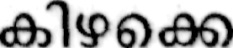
കിഴക്കെ
